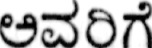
ಅವರಿಗೆ
